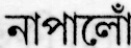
নাপালোঁ
